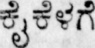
ಕೈಕೆಳಗೆ
